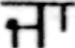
ਜਾ
